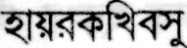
হায়রকখিবসু
